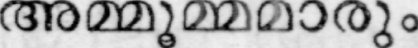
അമ്മൂമ്മമാരും
